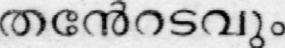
തന്റേടവും
